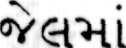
જેલમાં
